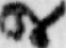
જ
